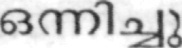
ഒന്നിച്ചു
